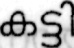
കട്ടി
